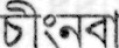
চীংনবা
